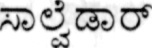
ಸಾಲ್ವೆಡಾರ್
